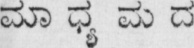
ಮಾಧ್ಯಮದ
